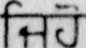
ਜਿਹੋ
